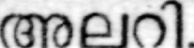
അലറി.
